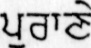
ਪੁਰਾਣੇ
